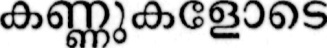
കണ്ണുകളോടെ
